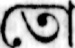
তো
